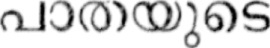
പാതയുടെ
